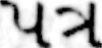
પત્ર
